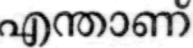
എന്താണ്
